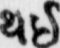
થઈ
